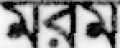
মরম
